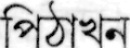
পিঠাখন
